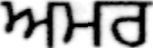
ਅਮਰ
